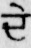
ਦੇ
